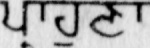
ਪ੍ਰਾਹੁਣਾ
